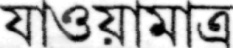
যাওয়ামাত্র
